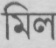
মিল
